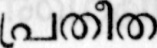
പ്രതീത
